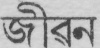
জীৱন
